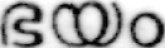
ഭയം
